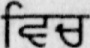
ਵਿਚ
